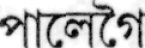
পালেগৈ
